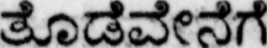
ತೊಡೆವೇನೆಗೆ
